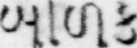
બાળક
